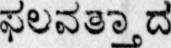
ಫಲವತ್ತಾದ
